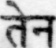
तेन
